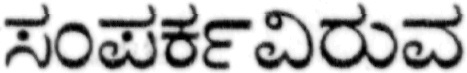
ಸಂಪರ್ಕವಿರುವ
